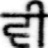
ਵੀ
